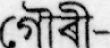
গৌৰী-
